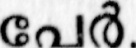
പേര്‍.
